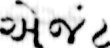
એજંટ
